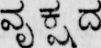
ವೃಕ್ಷದ
